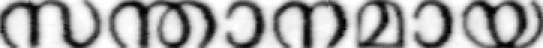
സന്താനമായ
